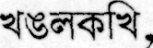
খঙলকখি,
